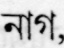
নাগ,
